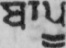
ਬਾਪੂ
